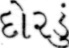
દોરડું
